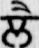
ਲੈ
